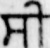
ਸੀ
